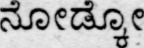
ನೋಡ್ಕೋ
